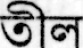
তীল
